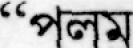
"পলম
